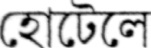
হোটেলে
